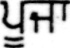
ਪੂਜਾ
